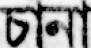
চানা
